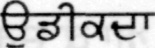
ਉਡੀਕਦਾ
